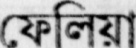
ফেলিয়া
